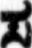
ಸ
